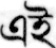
এই
